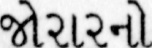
જોરારનો
